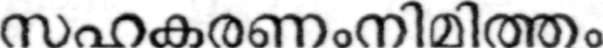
സഹകരണംനിമിത്തം
